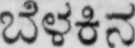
ಬೆಳಕಿನ
